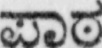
ಪಾಠ
